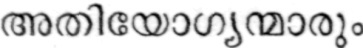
അതിയോഗ്യന്മാരും
